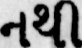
નથી
